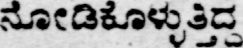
ನೋಡಿಕೊಳ್ಳುತ್ತಿದ್ದ
